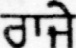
ਰਾਜੇ
